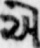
એ
